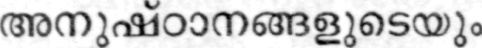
അനുഷ്ഠാനങ്ങളുടെയും
